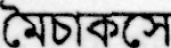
মৈচাকসে
